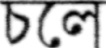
চলে
